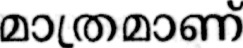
മാത്രമാണ്
